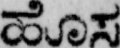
ಹೊಸ
